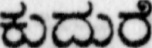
ಕುದುರೆ
